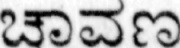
ಚಾವಣ
